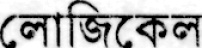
লোজিকেল
